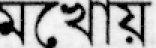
মখোয়
